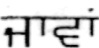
ਜਾਵਾਂ
